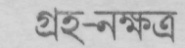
গ্ৰহ-নক্ষত্ৰ
